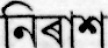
নিৰাশ
